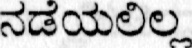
ನಡೆಯಲಿಲ್ಲ
